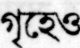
গৃহেও
